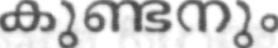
കുണ്ടനും
